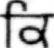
ਕਿ
